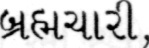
બ્રહ્મચારી,
